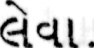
લેવા.
